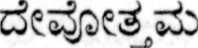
ದೇವೋತ್ತಮ
